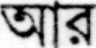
আর
